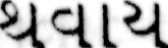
થવાય
